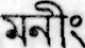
মনীং
